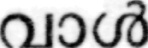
വാള്‍
